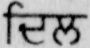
ਦਿਲ
